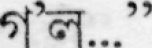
গ'ল..."
